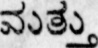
ಮತ್ತು
